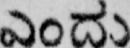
ಎಂದು
